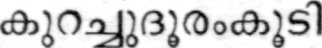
കുറച്ചുദൂരംകൂടി
